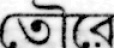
তৌরে
